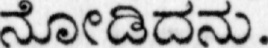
ನೋಡಿದನು.
